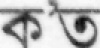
ক'ত
